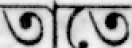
তাতে
